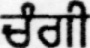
ਚੰਗੀ
